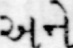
અને
